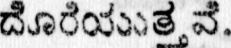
ದೊರೆಯುತ್ತವೆ.
